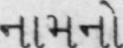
નામનો
